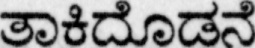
ತಾಕಿದೊಡನೆ
